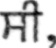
ਸੀ,
